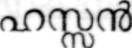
ഹസ്സന്‍
